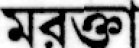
মরক্তা
